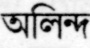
অলিন্দ
